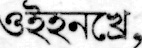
ওইহনখ্রে,
